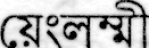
য়েংলম্মী
